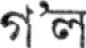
গ'ল
